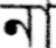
না
